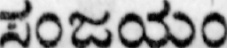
ಸಂಜಯಂ
